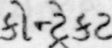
કોન્ટ્રેકટ
